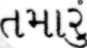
તમારું
